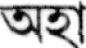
অহা
